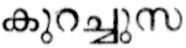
കുറച്ചുസ
